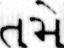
તમે
